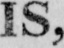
IS,
